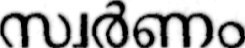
സ്വര്‍ണം
